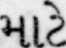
માટે
